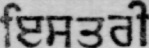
ਇਸਤਰੀ
